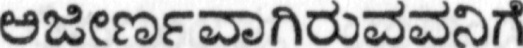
ಅಜೀರ್ಣವಾಗಿರುವವನಿಗೆ
